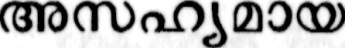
അസഹ്യമായ
